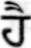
ਹੈ
